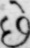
છે
